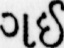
ગઈ
